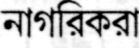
নাগরিকরা
